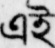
এই
